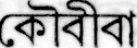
কৌবীবা
